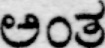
ಅಂತ
